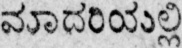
ಮಾದರಿಯಲ್ಲಿ
